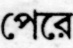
পেরে
